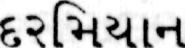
દરમિયાન
